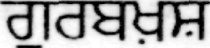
ਗੁਰਬਖ਼ਸ਼
